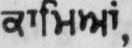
ਕਾਮਿਆਂ,
